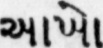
આખો
